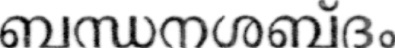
ബന്ധനശബ്ദം
